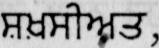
ਸ਼ਖ਼ਸੀਅਤ,
